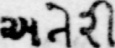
અનેરી
